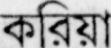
করিয়া
